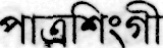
পাত্রশিংগী
